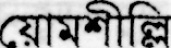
য়োমশীল্লি
